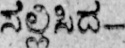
ಸಲ್ಲಿಸಿದ-
